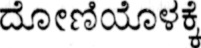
ದೋಣಿಯೊಳಕ್ಕೆ
